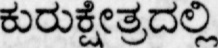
ಕುರುಕ್ಷೇತ್ರದಲ್ಲಿ
